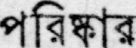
পরিষ্কার
